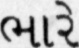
ભારે
